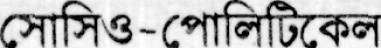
সোসিও-পোলিটিকেল
